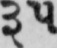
રૂપ
